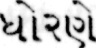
ધોરણે
